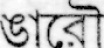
ঙারৌ
